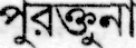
পুরক্তুনা
